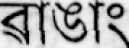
ৱাঙাং
